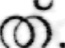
ത്.
